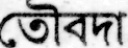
তৌবদা
